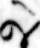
જે
